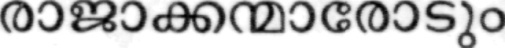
രാജാക്കന്മാരോടും
